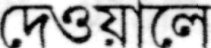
দেওয়ালে
